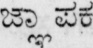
ಜ್ಞಾಪಕ
